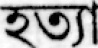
হত্যা
